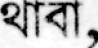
থাবা,
